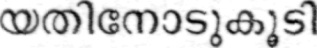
യതിനോടുകൂടി
